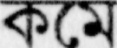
কমে
